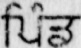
ਪਿੰਡ
